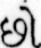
છો
